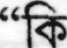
"কি
